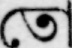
তো
